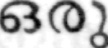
ഒരു
